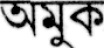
অমুক
